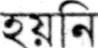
হয়নি
